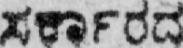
ಸರ್ಕಾರದ
